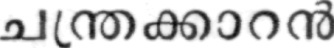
ചന്ത്രക്കാറന്‍
